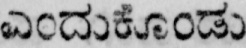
ಎಂದುಕೊಂಡು
